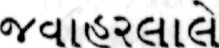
જવાહરલાલે
